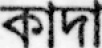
কাদা
